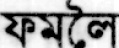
ফমলৈ
